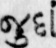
જુદાં
